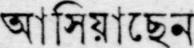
আসিয়াছেন
